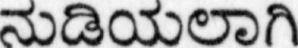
ನುಡಿಯಲಾಗಿ
